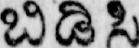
ಬಿಡಿಸಿ
